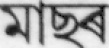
মাছৰ
